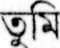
তুমি
